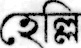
হেল্লি
